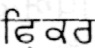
ਫ਼ਿਕਰ
